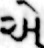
એ
